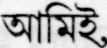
আমিই,
